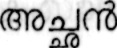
അച്ഛന്‍
